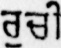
ਰੁਚੀ
